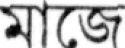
মাজে
